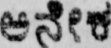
ಅನೇಕ
